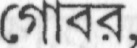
গোবর,
